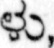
ಳು,
